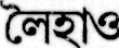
লৈহাও
